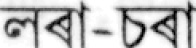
লৰা-চৰা
